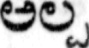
ಅಲ್ಪ
